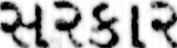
સરકાર
